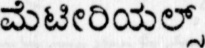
ಮೆಟೀರಿಯಲ್ಸ್
